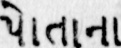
પોતાના
